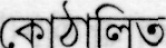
কোঠালিত
